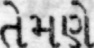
તેમણે
